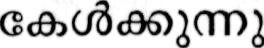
കേള്‍ക്കുന്നു
